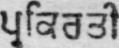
ਪ੍ਰਕਿਰਤੀ
